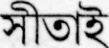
সীতাই
